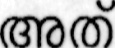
അത്
